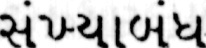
સંખ્યાબંધ
